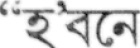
"হ'বনে
